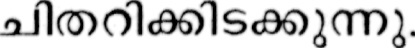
ചിതറിക്കിടക്കുന്നു.
